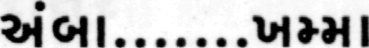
અંબા........ખમ્મા
